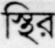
স্থির
